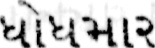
ધોધમાર
